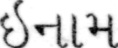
ઇનામ
